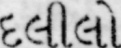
દલીલો
